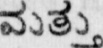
ಮತ್ತು
